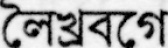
লৈখ্রবগে
